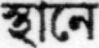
স্থানে
